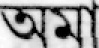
অমা
